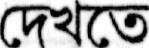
দেখতে
